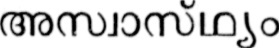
അസ്വാസ്ഥ്യം
